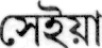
সেইয়া
